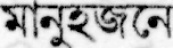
মানুহজনে
